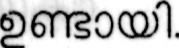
ഉണ്ടായി.
